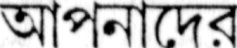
আপনাদের
